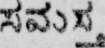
ಸಮಸ್ತ
